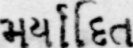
મર્યાદિત
